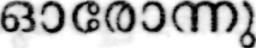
ഓരോന്നു
